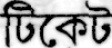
টিকেট
